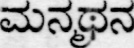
ಮನ್ಮಥನ
